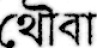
থৌবা
